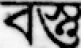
বস্তু
